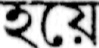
হয়ে
